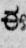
ಈ
